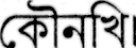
কৌনখি।
